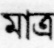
মাত্র
